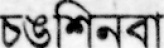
চঙশিনবা
